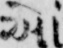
ઓં
